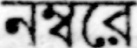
নম্বরে
